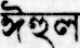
ঈহুল
